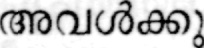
അവള്‍ക്കു
